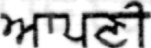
ਆਪਣੀ
